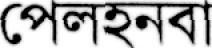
পেলহনবা
